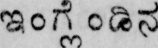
ಇಂಗ್ಲೆಂಡಿನ
